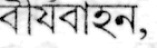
বীর্যবাহন,
